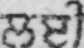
ਲਈ
